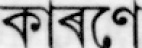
কাৰণে
